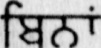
ਬਿਨਾਂ
